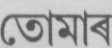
তোমাৰ
